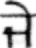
ਜੇ
